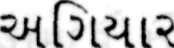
અગિયાર
